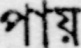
পায়
